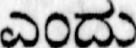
ಎಂದು
